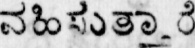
ವಹಿಸುತ್ತಾರೆ
